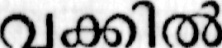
വക്കില്‍
